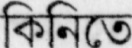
কিনিতে
